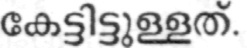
കേട്ടിട്ടുളളത്.
